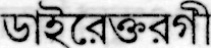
ডাইরেক্তরগী
